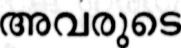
അവരുടെ
